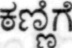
ಕಣ್ಣಿಗೆ
